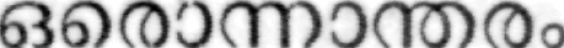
ഒരൊന്നാന്തരം
